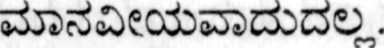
ಮಾನವೀಯವಾದುದಲ್ಲ.
